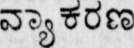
ವ್ಯಾಕರಣ
